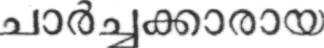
ചാര്‍ച്ചക്കാരായ
